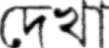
দেখা
